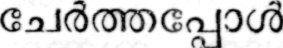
ചേര്‍ത്തപ്പോള്‍
